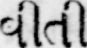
વીતી
